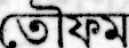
তৌফম
